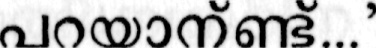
പറയാന്ണ്ട്...’
